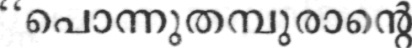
"പൊന്നുതമ്പുരാന്റെ
